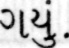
ગયું.
